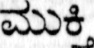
ಮುಕ್ತಿ
